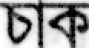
চাক
